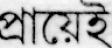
প্রায়েই
